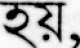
হয়,
